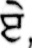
ਏ,
